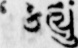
'કહ્યું
